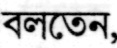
বলতেন,
